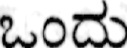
ಒಂದು
